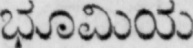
ಭೂಮಿಯ
